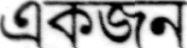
একজন
